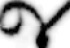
જ
